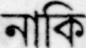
নাকি
